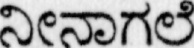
ನೀನಾಗಲೆ
